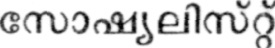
സോഷ്യലിസ്റ്റ്
